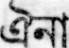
ঐনা
